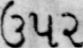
ઉપર
